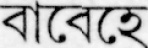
বাবেহে
